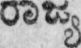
ರಾಜ್ಯ
